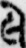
લે
